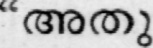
"അതു
